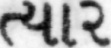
ત્યાર
